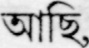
আছি,
